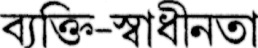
ব্যক্তি-স্বাধীনতা
